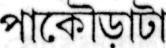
পাকৌড়াটা
